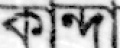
কান্দা
